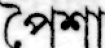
পৈশা
